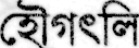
হৌগৎলি
